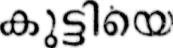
കുട്ടിയെ
